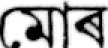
মোৰ
